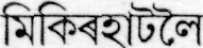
মিকিৰহাটলৈ
